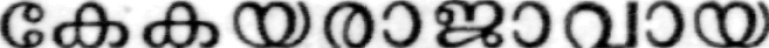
കേകയരാജാവായ
